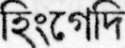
হিংগেদি
